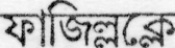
ফাজিল্লক্লে
